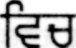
ਵਿਚ
